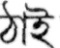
ঠাই
